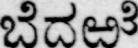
ಬೆದಱೆ
